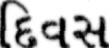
દિવસ
